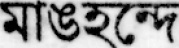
মাঙহন্দে
